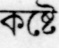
কষ্টে
